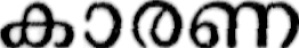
കാരണ
